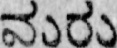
ಮರು
